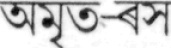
অমৃত-ৰস
